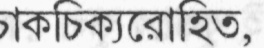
চাকচিক্যরোহিত,
